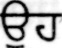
ਉਹ
